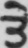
ਤੇ
